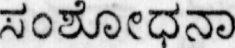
ಸಂಶೋಧನಾ
